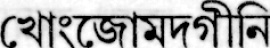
খোংজোমদগীনি
